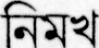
নিমখ
